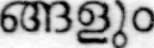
ങ്ങളും
